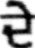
ਦੇ
